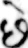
છે
